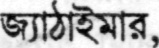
জ্যাঠাইমার,
